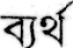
ব্যর্থ
